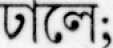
ঢালে;
